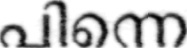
പിന്നെ
